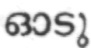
ഓടു
